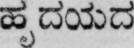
ಹೃದಯದ
